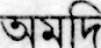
অমদি
